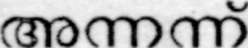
അന്നന്ന്
